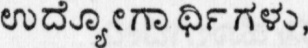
ಉದ್ಯೋಗಾರ್ಥಿಗಳು,
